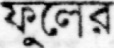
ফুলের
